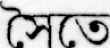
সৈতে
